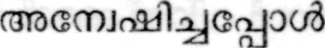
അന്വേഷിച്ചപ്പോള്‍
